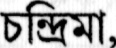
চন্দ্রিমা,
